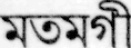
মতমগী
